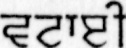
ਵਟਾਈ
